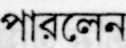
পারলেন
